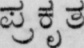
ಪ್ರಕೃತ
